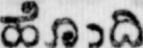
ಹೊಂದಿ
